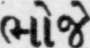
ભોજે
